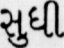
સુધી
